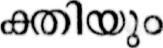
ക്തിയും
